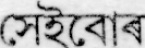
সেইবোৰ
